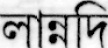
লান্নদি
